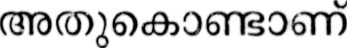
അതുകൊണ്ടാണ്
